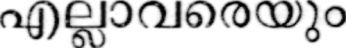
എല്ലാവരെയും
